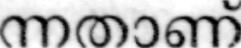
ന്നതാണ്
